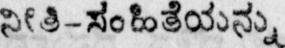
ನೀತಿ-ಸಂಹಿತೆಯನ್ನು
